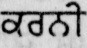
ਕਰਨੀ
